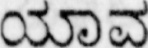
ಯಾವ
